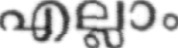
എല്ലാം
